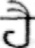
ਹੈ
